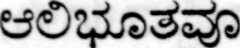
ಆಲಿಭೂತವೂ
